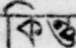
কিন্তু
